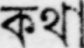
কথা
